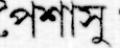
পৈশাসু
